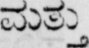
ಮತ್ತು
